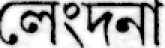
লেংদনা
